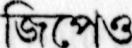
জিপেও
